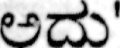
ಅದು’
